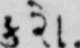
કરો.
